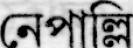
নেপাল্লি
